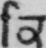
ਕਿ
